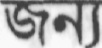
জন্য
